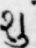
શું
